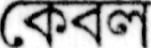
কেবল
